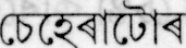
চেহেৰাটোৰ
